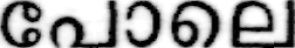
പോലെ
